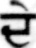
ਦੇ
